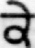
ਕੇ
